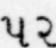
પર
